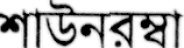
শাউনরকম্বা
